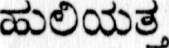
ಹುಲಿಯತ್ತ
